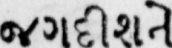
જગદીશને
